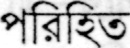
পরিহিত
